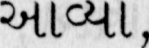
આવ્યા,
